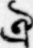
ঐ
